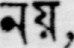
নয়,
